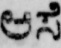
ಆಸೆ
